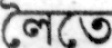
লৈতে
